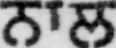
ਨਾਲ
